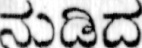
ನುಡಿದ
